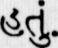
હતું.
